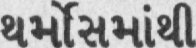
થર્મોસમાંથી
